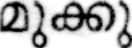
മുക്കു
